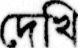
দেখি
